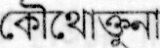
কৌথোক্তুনা
